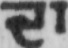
ਦਾ
